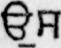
ਉਸ
